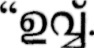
“ഉവ്വ്.
